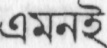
এমনই
